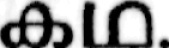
കഥ.
